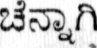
ಚೆನ್ನಾಗಿ
